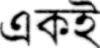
একই
